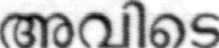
അവിടെ
